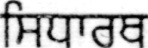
ਸਿਧਾਰਥ
